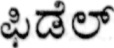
ಫಿಡೆಲ್
